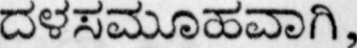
ದಳಸಮೂಹವಾಗಿ,
